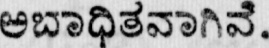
ಅಬಾಧಿತವಾಗಿವೆ.
